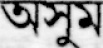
অসুম
